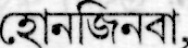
হোনজিনবা,
